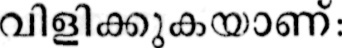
വിളിക്കുകയാണ്:
